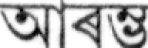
আৰম্ভ
